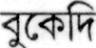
বুকেদি
